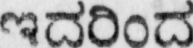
ಇದರಿಂದ
